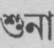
শুনা
